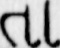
તો
